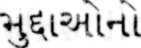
મુદ્દાઓનો
